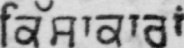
ਕਿੱਸਾਕਾਰਾਂ
